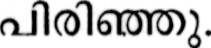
പിരിഞ്ഞു.
